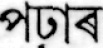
পঢ়াৰ
